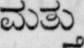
ಮತ್ತು
